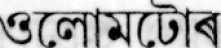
ওলোমটোৰ
